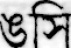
ঙসি
